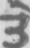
ਤੇ
